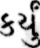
કર્યું
